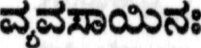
ವ್ಯವಸಾಯಿನಃ
